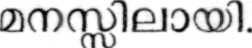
മനസ്സിലായി.
